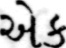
એક
